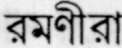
রমণীরা
